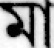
মা
